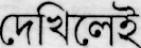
দেখিলেই
